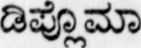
ಡಿಪ್ಲೊಮಾ
